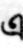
এ
